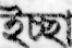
ইচ্ছা
